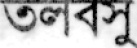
তলবসু
